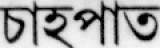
চাহপাত
